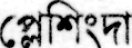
প্লেশিংদা
